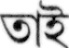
তাই
